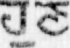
ਹੁਣ
